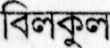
বিলকুল
